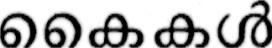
കൈകള്‍
